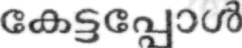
കേട്ടപ്പോള്‍
